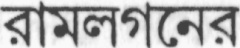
রামলগনের
